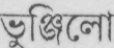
ভুঞ্জিলো
